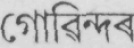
গোৱিন্দৰ
